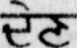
ਦੇਣ
